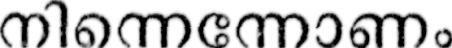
നിന്നെന്നോണം
